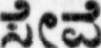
ಸೇವೆ
